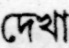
দেখা
